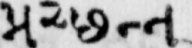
પ્રચ્છન્ન
